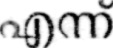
എന്ന്
